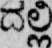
ದಲ್ಲಿ
